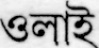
ওলাই
